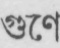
গুণে
